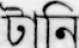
টানি
